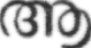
ആ
